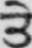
ਤੇ
